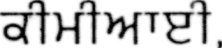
ਕੀਮੀਆਈ,
